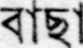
বাছা
